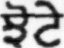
ਝੋਟੇ
